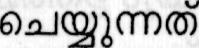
ചെയ്യുന്നത്
